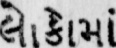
લોકોમાં
